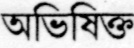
অভিষিক্ত
